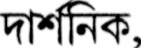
দার্শনিক,
